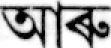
আৰু
